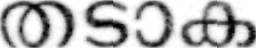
തടാക
